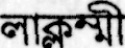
লাক্লম্মী
